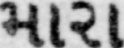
મારા
